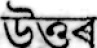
উত্তৰ
